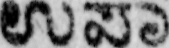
ಉಪಾ
